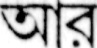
আর
